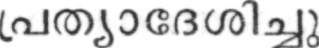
പ്രത്യാദേശിച്ചു
